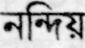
নন্দিয়
